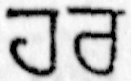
ਹਰ
